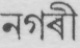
নগৰী
